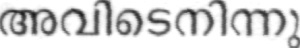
അവിടെനിന്നു
